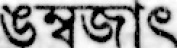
ঙম্বজাৎ
